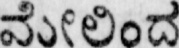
ಮೇಲಿಂದ
